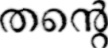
തന്റെ
